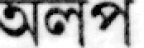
অলপ
